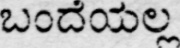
ಬಂದೆಯಲ್ಲ
